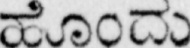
ಹೊಂದು
